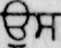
ਉਸ
